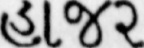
હાજર
